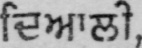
ਦਿਆਲੀ,
